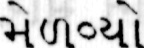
મેળવ્યો
